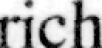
rich
